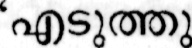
'എടുത്തു
